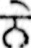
ਨੇ
